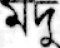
মদু
